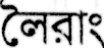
লৈরাং
